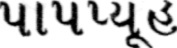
પાપપ્યૂહ
